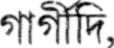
গার্গীদি,
